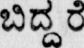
ಬಿದ್ದರೆ
